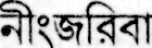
নীংজরিবা
